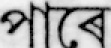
পাৰে
